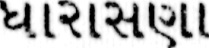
ધારાસણા
